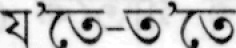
য'তে-ত'তে
